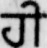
ਹੀ
